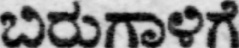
ಬಿರುಗಾಳಿಗೆ
